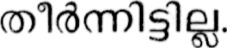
തീര്‍ന്നിട്ടില്ല.
